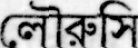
লৌরুসি
